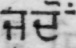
ਜਦੋਂ
